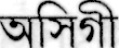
অসিগী
